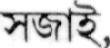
সজাই,
